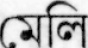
মেলি
